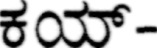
ಕಯ್-
